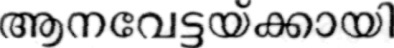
ആനവേട്ടയ്ക്കായി
